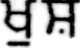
ਖੁਸ਼
